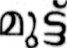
മുട്ട്
